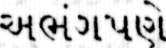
અભંગપણે
